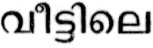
വീട്ടിലെ
